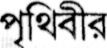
পৃথিবীর
